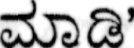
ಮಾಡಿ'
